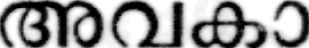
അവകാ
